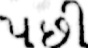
પછી
